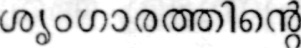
ശൃംഗാരത്തിന്റെ
